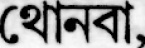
থোনবা,
